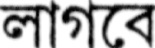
লাগবে
